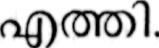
എത്തി.
